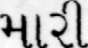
મારી
